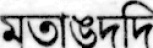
মতাঙদদি
